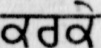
ਕਰਕੇ
